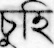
চুহি
